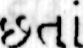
છતાં
